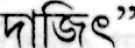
দাজিৎ”
